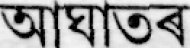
আঘাতৰ
